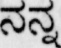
ನನ್ನ
